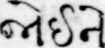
જોઈને
